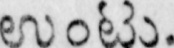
ಉಂಟು.
